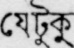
যেটুকু
